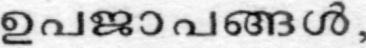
ഉപജാപങ്ങള്‍,
